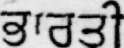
ਭਾਰਤੀ
